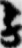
કે
